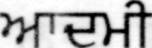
ਆਦਮੀ
